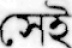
সেই
